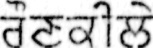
ਰੌਣਕੀਲੇ
